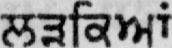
ਲੜਕਿਆਂ
